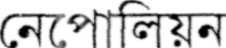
নেপোলিয়ন
